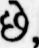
છે,
